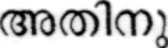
അതിനു
